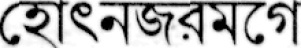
হোৎনজরমগে
